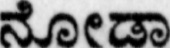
ನೋಡಾ
